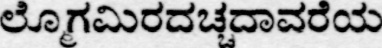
ಲ್ಮೊಗಮಿರದಚ್ಚದಾವರೆಯ
